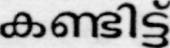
കണ്ടിട്ട്
